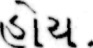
હોય.
